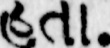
હતા.
